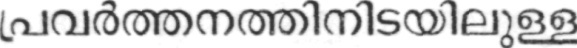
പ്രവര്‍ത്തനത്തിനിടയിലുള്ള
